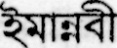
ইমান্নবী
